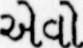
એવો
